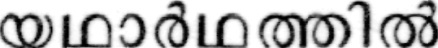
യഥാര്‍ഥത്തില്‍
